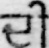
ਦੀ
